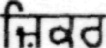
ਜ਼ਿਕਰ
